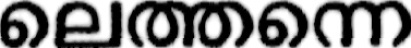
ലെത്തന്നെ
